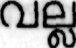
വല്ല
